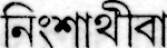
নিংশাথীবা
